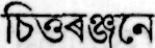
চিত্তৰঞ্জনে
